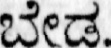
ಬೇಡ.
